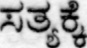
ಸತ್ಯಕ್ಕೆ
